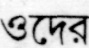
ওদের
